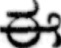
ಈ
